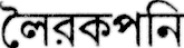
লৈরকপনি
